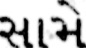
સામે
